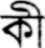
কী
